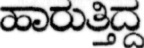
ಹಾರುತ್ತಿದ್ದ
